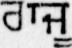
ਰਾਜੂ
